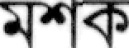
মশক
